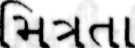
મિત્રતા
